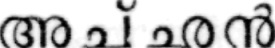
അച്ഛന്‍
